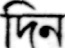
দিন
